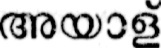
അയാള്
